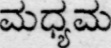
ಮಧ್ಯಮ
